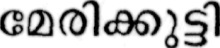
മേരിക്കുട്ടി
